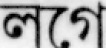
লগে
